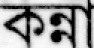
কন্না
